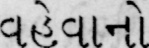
વહેવાનો
